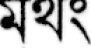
মথং
